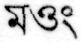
মওং
